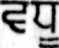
ਵਧੂ
